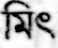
মিৎ
